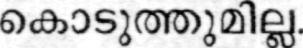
കൊടുത്തുമില്ല.
